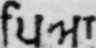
ਪਿਆ
